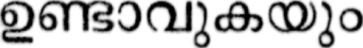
ഉണ്ടാവുകയും
